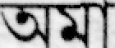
অমা
